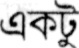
একটু
